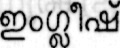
ഇംഗ്ലീഷ്
